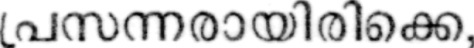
പ്രസന്നരായിരിക്കെ,
